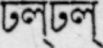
ঢল্‌ঢল্
